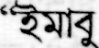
“ইমাবু
